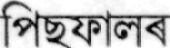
পিছফালৰ
